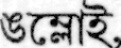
ঙম্লোই,
